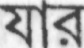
যার
